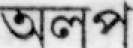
অলপ
